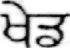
ਖੇਡ
